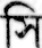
সি
